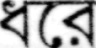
ধরে
